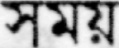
সময়
